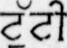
ਟੁੱਟੀ
